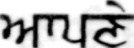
ਆਪਣੇ
